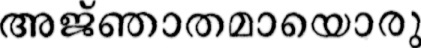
അജ്ഞാതമായൊരു
